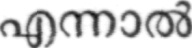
എന്നാല്‍
